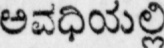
ಅವಧಿಯಲ್ಲಿ
